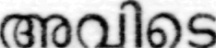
അവിടെ
